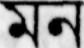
মন
